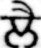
ਲੈ
